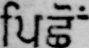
ਪਿਛੋਂ
